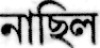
নাছিল
